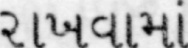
રાખવામાં
